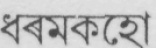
ধৰমকহো
